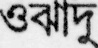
ওঝা
